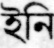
ইনি
